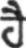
ਹੈ
